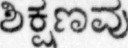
ಶಿಕ್ಷಣವು
